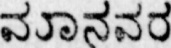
ಮಾನವರ
